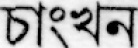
চাংখন
